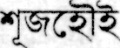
শূজহৌই
